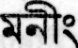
মনীং
